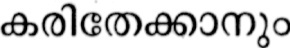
കരിതേക്കാനും
